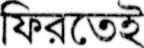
ফিরতেই
